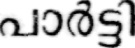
പാര്‍ട്ടി
